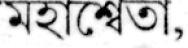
মহাশ্বেতা,
